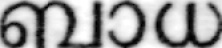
ബാധ
